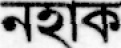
নহাক
